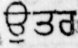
ਉਤਰ
